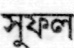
সুফল
